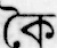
কৈ
